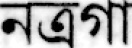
নত্রগা
